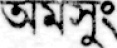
অমসুং
